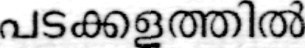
പടക്കളത്തില്‍
